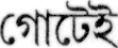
গোটেই
